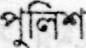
পুলিশ
